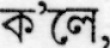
ক'লে,
